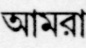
আমরা
